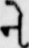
ને
